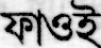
ফাওই
